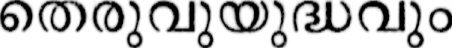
തെരുവുയുദ്ധവും
